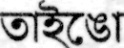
তাইঙো
